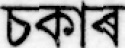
চকাৰ
